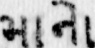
માનો
